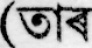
(তাৰ
